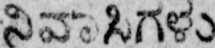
ನಿವಾಸಿಗಳು
